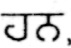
ਹਨ,
